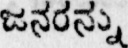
ಜನರನ್ನು
